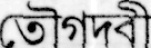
তৌগদবী
